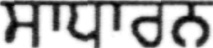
ਸਾਧਾਰਨ
